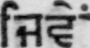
ਜਿਵੇਂ
